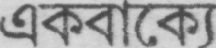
একবাক্যে
